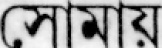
সোমায়
